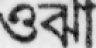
ওঝা
